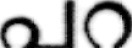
പറ
